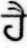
ਹੈ
